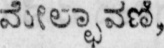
ಮೇಲ್ಛಾವಣಿ,
